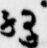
કરું
